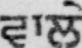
ਵਾਲੇ
